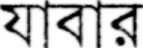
যাবার
